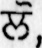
ਲੋ,
